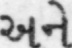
અને
